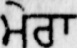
ਮੇਰਾ
